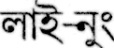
লাই-নুং
